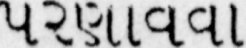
પરણાવવા
